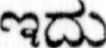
ಇದು
